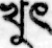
খুৎ
